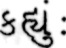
કહ્યું:
